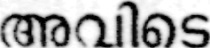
അവിടെ
